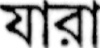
যারা
